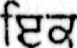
ਇਕ
